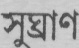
সুঘ্ৰাণ
